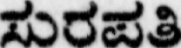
ಸುರಪತಿ
